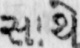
સાથે
